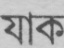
যাক
